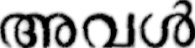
അവള്‍
